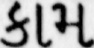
કામ
